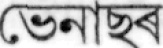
ভেনাছৰ
